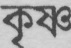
কৃষ্ণ
